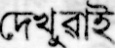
দেখুৱাই
